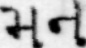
મન
